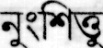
নুংশিত্তু
